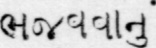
ભજવવાનું
